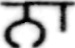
ਨਾ
